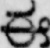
ಈ
